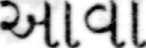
આવા
